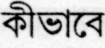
কীভাবে
